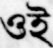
ওই
